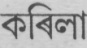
কৰিলা
